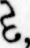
દે,
